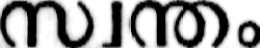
സ്വന്തം
